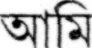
আমি
